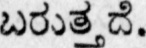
ಬರುತ್ತದೆ.
